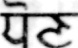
ਧੋਣ
